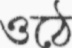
ওঠে
